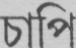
চাপি
